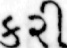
કરી
